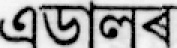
এডালৰ
